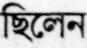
ছিলেন
